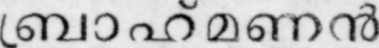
ബ്രാഹ്മണന്‍
